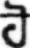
ਹੋ
